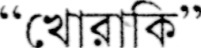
“খোরাকি”
